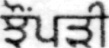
ਝੌਂਪੜੀ
